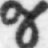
જ
